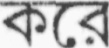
করে
